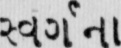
સ્વર્ગના
